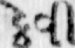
કેવી
